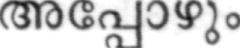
അപ്പോഴും
